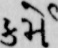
કર્મે
